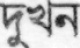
দুখন
